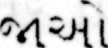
જાઓ
